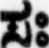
ಸಃ
